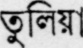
তুলিয়া
